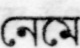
নেমে
